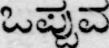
ಒಪ್ಪುವ
